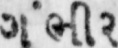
ગંભીર
